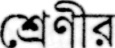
শ্রেণীর
